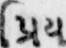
પ્રિય
